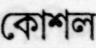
কোশল
